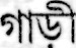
গাড়ী
